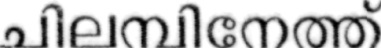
ചിലമ്പിനേത്ത്
